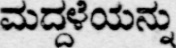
ಮದ್ದಳೆಯನ್ನು
